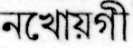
নখোয়গী
